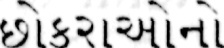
છોકરાઓનો
